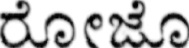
ರೋಜೊ
